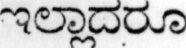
ಇಲ್ಲಾದರೂ
